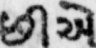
છીએ
